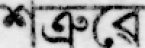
শত্রুৱে
